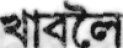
খাবলৈ
